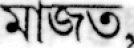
মাজত,
